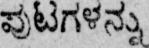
ಪುಟಗಳನ್ನು
